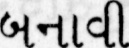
બનાવી
